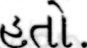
હતો.
